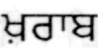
ਖ਼ਰਾਬ
